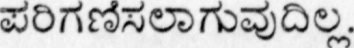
ಪರಿಗಣಿಸಲಾಗುವುದಿಲ್ಲ.
